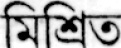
মিশ্রিত
